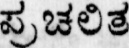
ಪ್ರಚಲಿತ
